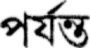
পর্যন্ত
